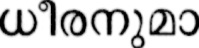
ധീരനുമാ
